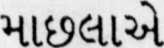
માછલાએ
